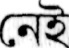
নেই
